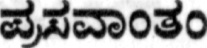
ಪ್ರಸವಾಂತ೦
